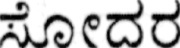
ಸೋದರ
